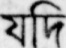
যদি
